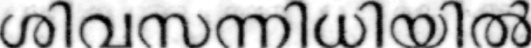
ശിവസന്നിധിയില്‍
